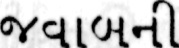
જવાબની
